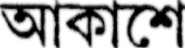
আকাশে
